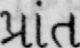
પ્રાંત
